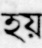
হয়
